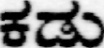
ಕಡು
